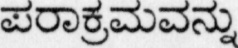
ಪರಾಕ್ರಮವನ್ನು
